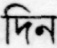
দিন
